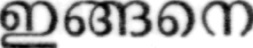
ഇങ്ങനെ
